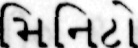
મિનિટો
